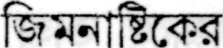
জিমনাষ্টিকের
